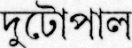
দুটোপাল
